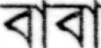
বাবা
